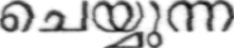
ചെയ്യുന്ന
